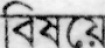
বিষয়ে
